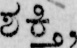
ಶಕ್ತಿ,
